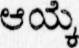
ಆಯ್ಕೆ
